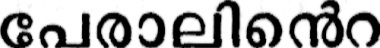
പേരാലിന്റെ
